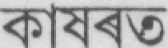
কাষৰত
